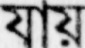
য়ায়
